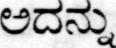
ಅದನ್ನು
